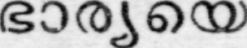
ഭാര്യയെ
